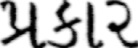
પ્રકાર
